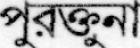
পুরক্তুনা
